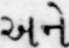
અને
